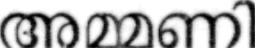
അമ്മണി
